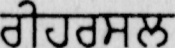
ਰੀਹਰਸਲ
